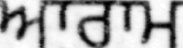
ਆਰਾਮ
